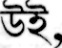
উই,
